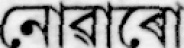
নোৱাৰো
